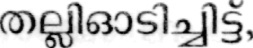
തല്ലിഓടിച്ചിട്ട്,
